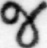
જ
